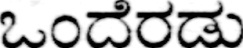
ಒಂದೆರಡು
